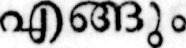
എങ്ങും
